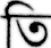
তি
